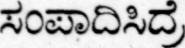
ಸಂಪಾದಿಸಿದ್ರೆ
